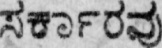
ಸರ್ಕಾರವು
